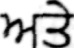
ਅਤੇ
